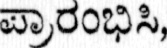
ಪ್ರಾರಂಭಿಸಿ,
